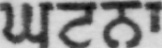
ਘਟਨਾ
